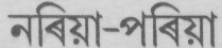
নৰিয়া-পৰিয়া
